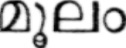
മൂലം
